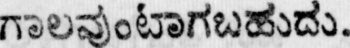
ಗಾಲವುಂಟಾಗಬಹುದು.
